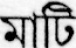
মাটি
